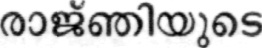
രാജ്ഞിയുടെ
